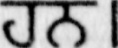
ਹਨ।
